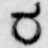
ರ
